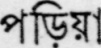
পড়িয়া
